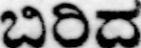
ಬಿರಿದ
